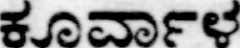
ಕೂರ್ವಾಳ
